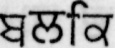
ਬਲਕਿ
